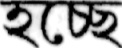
হচ্ছে
